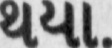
થયા.
